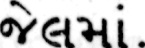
જેલમાં.
